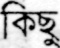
কিছু
